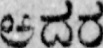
ಅದರ
